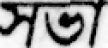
সভা
